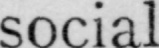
social
